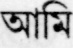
আমি
